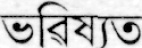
ভৱিষ্যত
